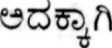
ಅದಕ್ಕಾಗಿ
